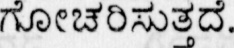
ಗೋಚರಿಸುತ್ತದೆ.
